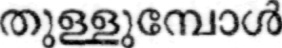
തുള്ളുമ്പോള്‍
